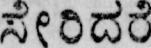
ಸೇರಿದರೆ
